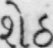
શેઠ
